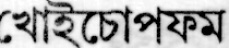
খোইচোপফম
